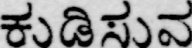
ಕುಡಿಸುವ
